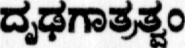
ದೃಢಗಾತ್ರತ್ವಂ
